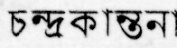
চন্দ্রকান্তনা
